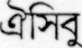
ঐসিবু
